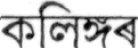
কলিঙ্গৰ
